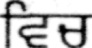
ਵਿਚ
